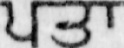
ਪਤਾ
